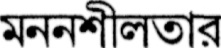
মননশীলতার
